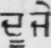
ਦੂਜੇ
